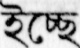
ইচ্ছে
